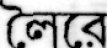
লৈরে
